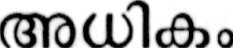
അധികം
